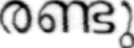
രണ്ടു
